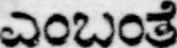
ಎಂಬಂತೆ
